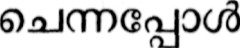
ചെന്നപ്പോള്‍
